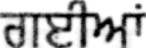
ਗਈਆਂ
